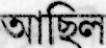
আছিল
